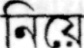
নিয়ে
